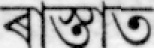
ৰাস্তাত
